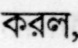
করল,
